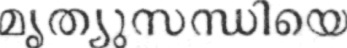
മൃത്യുസന്ധിയെ
